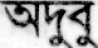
অদুবু
